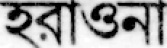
হরাওনা
